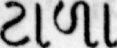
ટાળા
